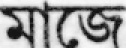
মাজে
